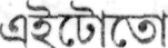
এইটোতো
